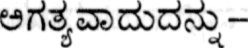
ಅಗತ್ಯವಾದುದನ್ನು-
